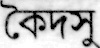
কৈদসু
